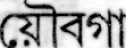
য়ৌবগা
